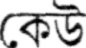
কেউ
